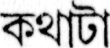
কথাটা
